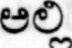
ಅಲ್ಲಿ
